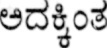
ಅದಕ್ಕಿಂತ
